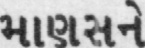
માણસને
